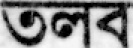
তলব
